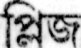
প্লিজ
